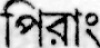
পিরাং
